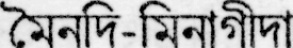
মৈনদি-মিনাগীদা
